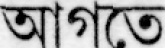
আগতে
